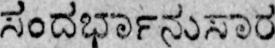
ಸಂದರ್ಭಾನುಸಾರ
